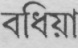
বধিয়া
